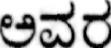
ಅವರ
